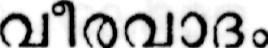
വീരവാദം
